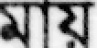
মায়
